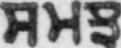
ਸਮਝ
